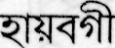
হায়বগী
